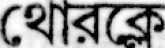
থোরক্লে
